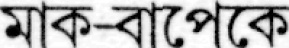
মাক-বাপেকে
